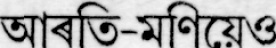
আৰতি-মণিয়েও
